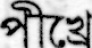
পীখ্রে
